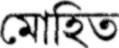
মোহিত
